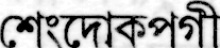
শেংদোকপগী
